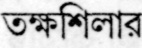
তক্ষশিলার
